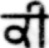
ਕੀ
